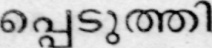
പ്പെടുത്തി
